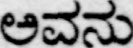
ಅವನು
